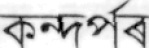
কন্দর্পৰ
